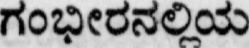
ಗಂಭೀರನಲ್ಲಿಯ
